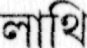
লাথি
